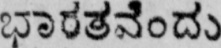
ಭಾರತವೆಂದು
